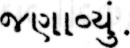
જણાવ્યું.
